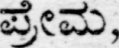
ಪ್ರೇಮ,
